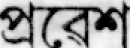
প্রৱেশ
